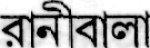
রানীবালা
